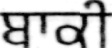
ਬਾਕੀ
